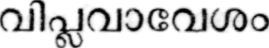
വിപ്ലവാവേശം
